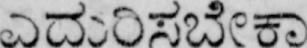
ಎದುರಿಸಬೇಕಾ
